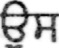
ਉਸ
